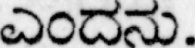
ಎಂದನು.
